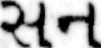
સન
